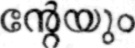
ന്റേയും
